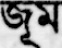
জূম
